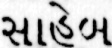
સાહેબ
